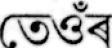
তেওঁৰ
